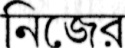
নিজের
